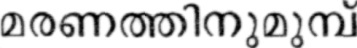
മരണത്തിനുമുമ്പ്
